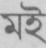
মই
